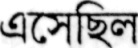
এসেছিল
